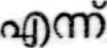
എന്ന്
